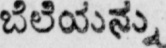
ಬೆಲೆಯನ್ನು
